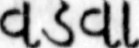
વડવા
